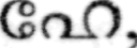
ഹേ,
